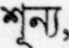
শূন্য,
